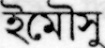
ইমৌসু
